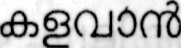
കളവാന്‍
